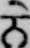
ਨੇ
